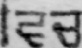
ਵਿਚ
